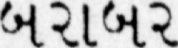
બરાબર
